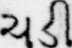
ચડી
